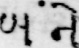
બંને
